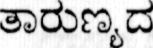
ತಾರುಣ್ಯದ
